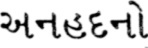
અનહદનો
